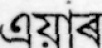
এয়াৰ
